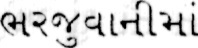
ભરજુવાનીમાં
